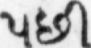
પછી
